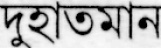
দুহাতমান
